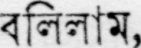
বলিলাম,
